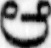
ಆ
